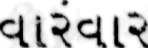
વારંવાર
